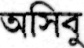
অসিবু
